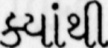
ક્યાંથી
